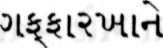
ગફ્ફારખાને
